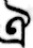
ঐ
